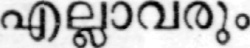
എല്ലാവരും
